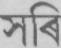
সৰি
